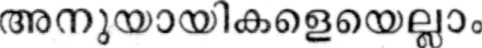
അനുയായികളെയെല്ലാം
